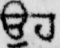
ਉਹ
